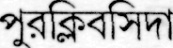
পুরক্লিবসিদা
